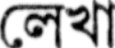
লেখা
